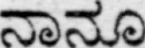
ನಾನೂ
